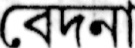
বেদনা
